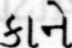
કાને
